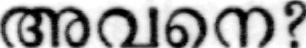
അവനെ?
